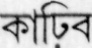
কাঢ়িব
